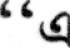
“এ
